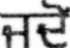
ਜਦੋਂ
